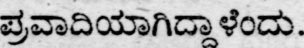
ಪ್ರವಾದಿಯಾಗಿದ್ದಾಳೆಂದು.
